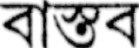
বাস্তব
